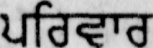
ਪਰਿਵਾਰ
